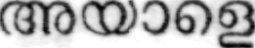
അയാളെ
